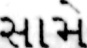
સામે
